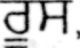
ਰੂਸ,
